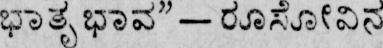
ಭಾತೃಭಾವ”-ರೂಸೋವಿನ
